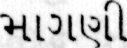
માગણી
